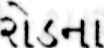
રોડના
